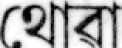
থোৱা
